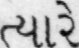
ત્યારે
